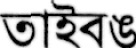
তাইবঙ
